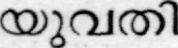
യുവതി
